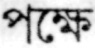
পক্ষে
